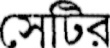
সেটির
